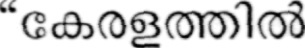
"കേരളത്തില്‍
